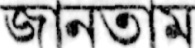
জানতাম
